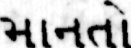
માનતો
